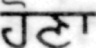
ਹੋਣਾ
